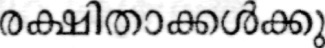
രക്ഷിതാക്കള്‍ക്കു
